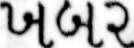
ખબર
